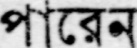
পারেন
